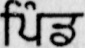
ਪਿੰਡ
